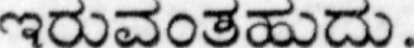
ಇರುವಂತಹುದು.
